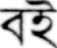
বই
